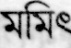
মমিৎ
